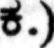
ಕ.)
